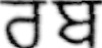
ਰਬ
